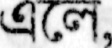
এলে,
